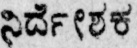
ನಿರ್ದೇಶಕ
